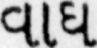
વાઘ
